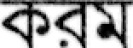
করম
